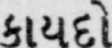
કાયદો
